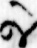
જે
